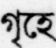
গৃহে
